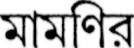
মামণির
